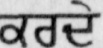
ਕਰਦੇ
